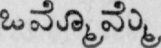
ಒಮ್ಮೊಮ್ಮೆ
